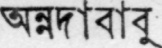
অন্নদাবাবু
